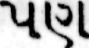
પણ
